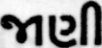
જાણી
